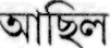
আছিল
